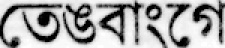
তেঙবাংগে
